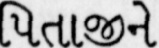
પિતાજીને
